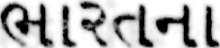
ભારતના
